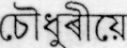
চৌধুৰীয়ে
